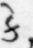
કે,
